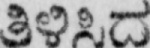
ತಿಳಿಸಿದ
